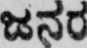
ಜನರ
